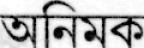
অনিমক
